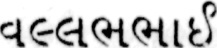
વલ્લભભાઈ
